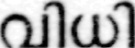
വിധി
